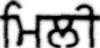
ਮਿਲੀ
